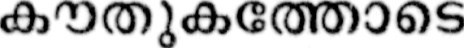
കൌതുകത്തോടെ
